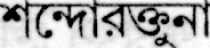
শন্দোরক্তুনা
